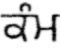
ਕੰਮ
